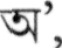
অ',
